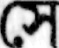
সে
